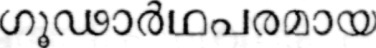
ഗൂഢാര്‍ഥപരമായ
